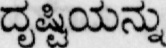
ದೃಷ್ಟಿಯನ್ನು
